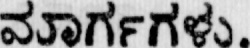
ಮಾರ್ಗಗಳು.
